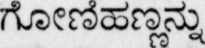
ಗೋಣಿಹಣ್ಣನ್ನು
